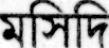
মসিদি
